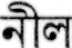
নীল
